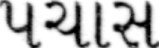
પચાસ
